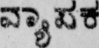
ವ್ಯಾಪಕ
